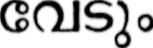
വേടും
